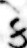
કે
